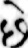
છે
